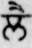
ਲੈ
